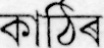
কাঠিৰ
